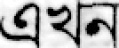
এখন
